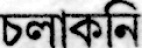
চলাকনি
